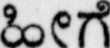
ಹೀಗೆ
